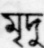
মৃদু
